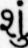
શું
